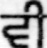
ਵੀ
